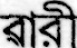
ৱারী
